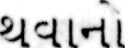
થવાનો
